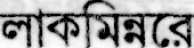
লাকমিন্নরে
